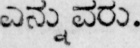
ಎನ್ನುವರು.
